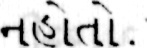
નહોતો.
